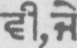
ਵੀ,ਜੇ
